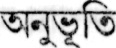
অনুভূতি
